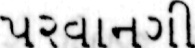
પરવાનગી
